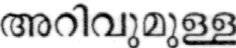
അറിവുമുള്ള
